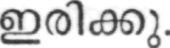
ഇരിക്കു.
